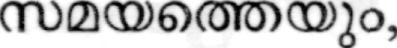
സമയത്തെയും,
